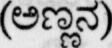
(ಅಣ್ಣನ)
